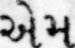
એમ
